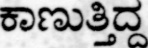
ಕಾಣುತ್ತಿದ್ದ
